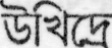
উখিদ্রে
